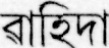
ৱাহিদা
